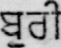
ਬੁਰੀ
